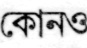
কোনও
